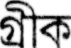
গ্রীক
